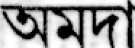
অমদা
